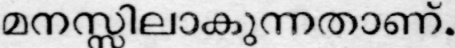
മനസ്സിലാകുന്നതാണ്.
